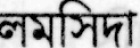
লমসিদা
